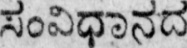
ಸಂವಿಧಾನದ
